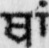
ਥਾਂ
